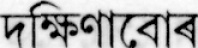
দক্ষিণাবোৰ
